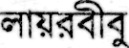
লায়রবীবু
